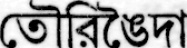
তৌরিঙৈদা
